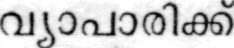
വ്യാപാരിക്ക്
